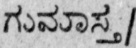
ಗುಮಾಸ್ತ/
